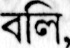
বলি,
